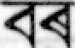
বৰ
